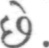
છે.
